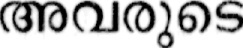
അവരുടെ
